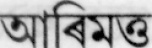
আৰিমত্ত
